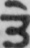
ਤੇ
